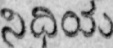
ನಿಧಿಯ
